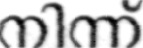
നിന്ന്
